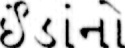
ઇંડાંનો
